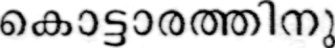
കൊട്ടാരത്തിനു
